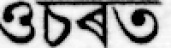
ওচৰত
